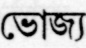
ভোজ্য
